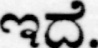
ಇದೆ.
